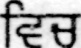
ਵਿਚ
